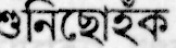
শুনিছোহঁক
